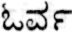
ಓರ್ವ
